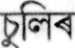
চুলিৰ
